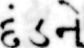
દંડને
